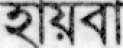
হায়বা
